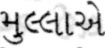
મુલ્લાએ
